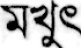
মখুৎ
